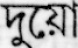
দুয়ো
